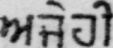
ਅਜੇਹੀ
